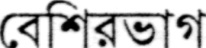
বেশিরভাগ
